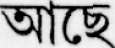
আছে
